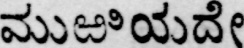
ಮುಱಿಯದೇ
